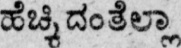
ಹೆಚ್ಚಿದಂತೆಲ್ಲಾ
